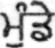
ਮੁੰਡੇ
